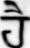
ਹੈ
